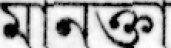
মানক্তা
